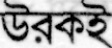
উরকই
